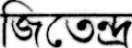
জিতেন্দ্র
